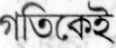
গতিকেই
